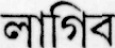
লাগিব
